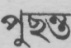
পুছন্ত
